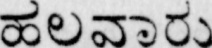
ಹಲವಾರು
